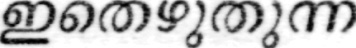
ഇതെഴുതുന്ന
